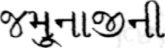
જમુનાજીની
